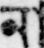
না
